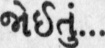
જોઈતું...
